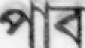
পাব
